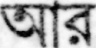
আর
